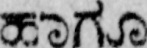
ಹಾಗೂ
